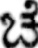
ಚೆ
